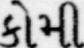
કોમી
